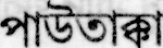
পাউতাক্কা
